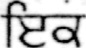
ਇਕ
